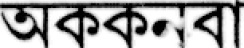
অককনবা
